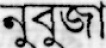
নুবুজা
